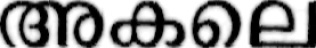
അകലെ
